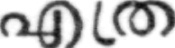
എത്ര
